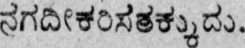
ನಗದೀಕರಿಸತಕ್ಕುದು.
